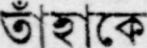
তাঁহাকে
